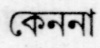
কেননা
